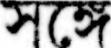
সঙ্গে
